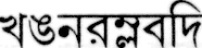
খঙনরম্লবদি
